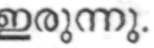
ഇരുന്നു.
